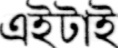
এইটাই
